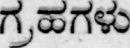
ಗ್ರಹಗಳು
